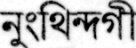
নিংথিন্দগী
